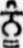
ਨੂੰ
